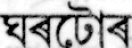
ঘৰটোৰ
